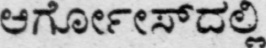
ಆರ್ಗೋಸ್ದಲ್ಲಿ
